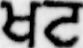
ਖਟ
